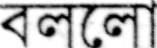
বললো
